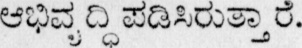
ಅಭಿವೃದ್ಧಿಪಡಿಸಿರುತ್ತಾರೆ.
